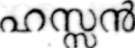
ഹസ്സന്‍
